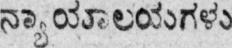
ನ್ಯಾಯಾಲಯಗಳು
